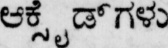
ಆಕ್ಸೈಡ್‌ಗಳು
